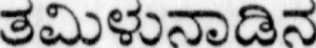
ತಮಿಳುನಾಡಿನ
